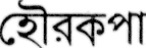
হৌরকপা
